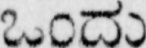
ಒಂದು
